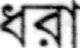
ধরা
